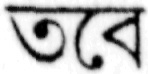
তবে
